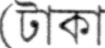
(টাকা
